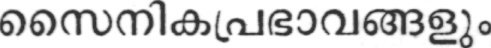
സൈനികപ്രഭാവങ്ങളും
